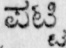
ಪಟ್ಟಿ
